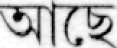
আছে
